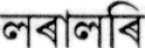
লৰালৰি
